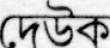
দেউক
